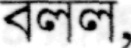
বলল,
